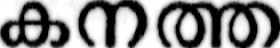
കനത്ത
